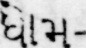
ધોમ-
